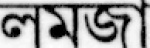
লমজা
